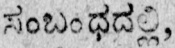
ಸಂಬಂಧದಲ್ಲಿ,
